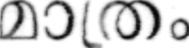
മാത്രം
